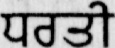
ਧਰਤੀ
